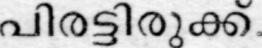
പിരട്ടിരുക്ക്.
